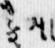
ફૈબા
